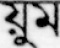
য়ুম
